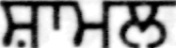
ਸ਼ਾਮਲ
